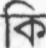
কি
